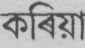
কৰিয়া
